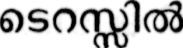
ടെറസ്സില്‍
